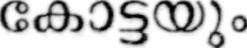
കോട്ടയും
